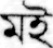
মই
